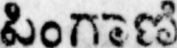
ಪಿಂಗಾಣಿ
